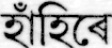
হাঁহিৰে
